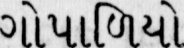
ગોપાળિયો
